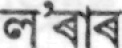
ল'ৰাৰ
